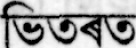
ভিতৰত
